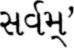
સર્વમ્'
